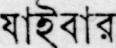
যাইবার
